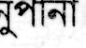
নুপীনা
